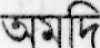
অমদি
